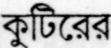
কুটিরের
